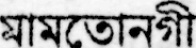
মামতোনগী
